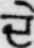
ਦੇ
